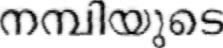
നമ്പിയുടെ
